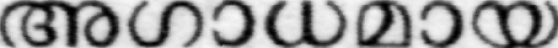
അഗാധമായ
